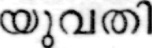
യുവതി
